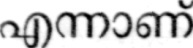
എന്നാണ്
